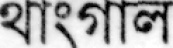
থাংগাল
